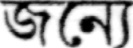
জন্যে
